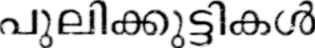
പുലിക്കുട്ടികള്‍
